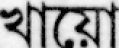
খায়ো
